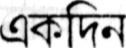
একদিন
